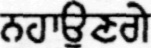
ਨਹਾਉਣਗੇ
